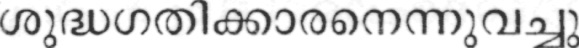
ശുദ്ധഗതിക്കാരനെന്നുവച്ചു
